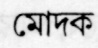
মোদক
